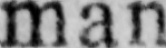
man
